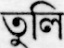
তুলি
